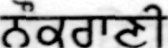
ਨੌਕਰਾਣੀ
